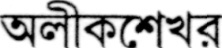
অলীকশেখর
